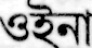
ওইনা
